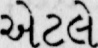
એટલે
